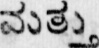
ಮತ್ತು
